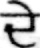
ਦੇ
